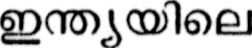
ഇന്ത്യയിലെ
